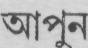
আপুন
